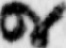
જ
